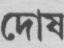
দোষ
